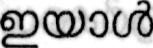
ഇയാള്‍
